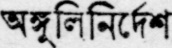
অঙ্গুলিনির্দেশ
